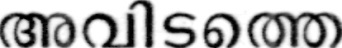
അവിടത്തെ
